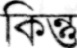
কিন্তু
